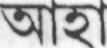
আহা
